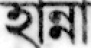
হান্না
